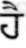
ਹੈ
